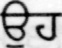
ਉਹ
